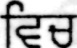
ਵਿਚ
